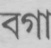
বগা
